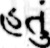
હતું
